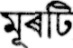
মূৰটি
